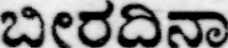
ಬೀರದಿನಾ
